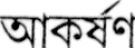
আকর্ষণ
